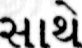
સાથે
